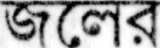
জলের
